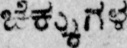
ಚೆಕ್ಕುಗಳ
